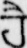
ਹੈ
